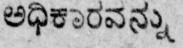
ಅಧಿಕಾರವನ್ನು
